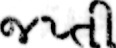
જપ્તી
